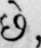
છે,
